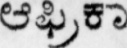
ಆಫ್ರಿಕಾ
